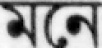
মনে
